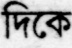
দিকে
